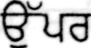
ਉੱਪਰ
